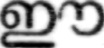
ഈ
